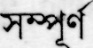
সম্পূর্ণ
